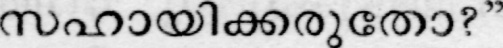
സഹായിക്കരുതോ?"
